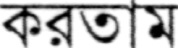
করতাম
